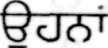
ਉਹਨਾਂ
